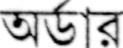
অর্ডার
